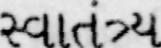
સ્વાતંત્ર્ય
